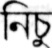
নিচু
